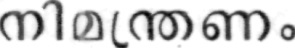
നിമന്ത്രണം
